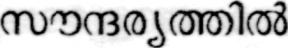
സൌന്ദര്യത്തില്‍
